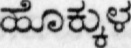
ಹೊಕ್ಕುಳ
